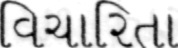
વિચારિતા
